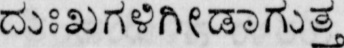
ದುಃಖಗಳಿಗೀಡಾಗುತ್ತ
